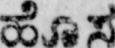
ಹೊಸ
